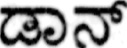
ಡಾನ್
